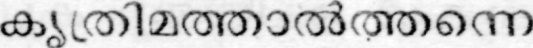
കൃത്രിമത്താല്‍ത്തന്നെ
